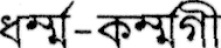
ধর্ম্ম-কর্ম্মগী
